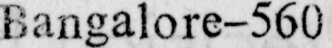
Bangalore-560
